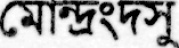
মোন্দ্রংদসু
